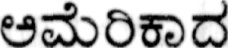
ಅಮೆರಿಕಾದ
